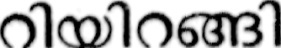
റിയിറങ്ങി
